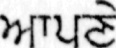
ਆਪਣੇ
